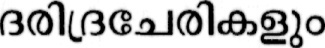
ദരിദ്രചേരികളും
